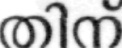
തിന്
